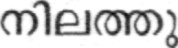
നിലത്തു
